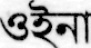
ওইনা
